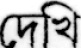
দেখি
